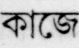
কাজে
